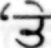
'ਤੇ
